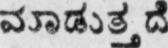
ಮಾಡುತ್ತದೆ
